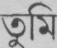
তুমি
